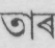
তাৰ
